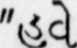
"હવે
